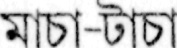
মাচা-টাচা
